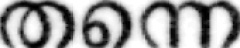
തന്നെ
